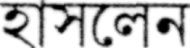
হাসলেন
